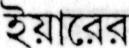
ইয়ারের
